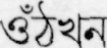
ওঁঠখন
